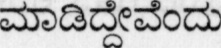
ಮಾಡಿದ್ದೇವೆಂದು
